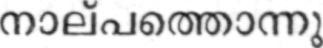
നാല്പത്തൊന്നു
